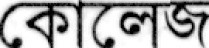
কোলেজ
